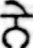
ਨੇ
